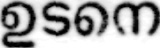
ഉടനെ
